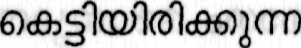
കെട്ടിയിരിക്കുന്ന
